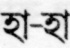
হা-হা
